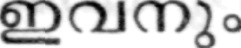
ഇവനും
